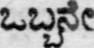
ಒಬ್ಬನೇ
